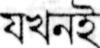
যখনই
